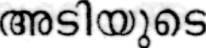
അടിയുടെ
